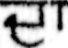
ਦਾ
